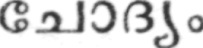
ചോദ്യം
